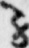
કે
